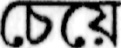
চেয়ে
